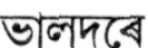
ভালদৰে
